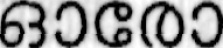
ഓരോ
